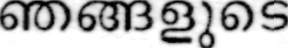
ഞങ്ങളുടെ
